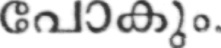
പോകും.
